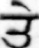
ਤੇ
